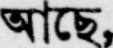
আছে,
